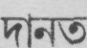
দানত
